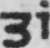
ਤਾਂ
